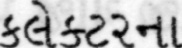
કલેકટરના
